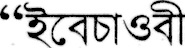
“ইবেচাওবী
